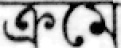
ক্রমে
